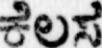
ಕೆಲಸ
